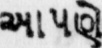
આપણે
